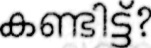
കണ്ടിട്ട്?
